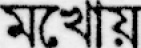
মখোয়
